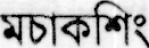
মচাকশিং
